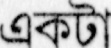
একটা
